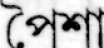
পৈশা
